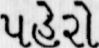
પહેરો
